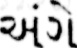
અંગે
